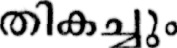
തികച്ചും
